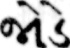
જોડે
